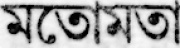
মতোমতা
